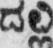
ದಲ್ಲಿ
